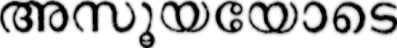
അസൂയയോടെ
